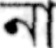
না
